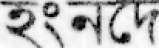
হংনদে
